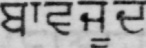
ਬਾਵਜੂਦ
